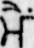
ਮੈਂ
